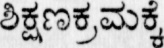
ಶಿಕ್ಷಣಕ್ರಮಕ್ಕೆ
